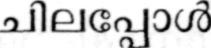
ചിലപ്പോള്‍
